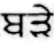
ਬੜੇ
